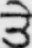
ਤੇ
